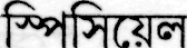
স্পিসিয়েল
